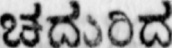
ಚದುರಿದ
